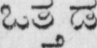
ಒತ್ತಡ
